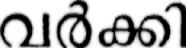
വര്‍ക്കി
